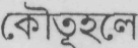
কৌতূহলে
